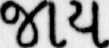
જાય
